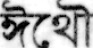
ঈথৌ
